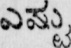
ಎಷ್ಟು
